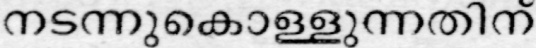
നടന്നുകൊള്ളുന്നതിന്
